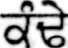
ਕੰਢੇ
